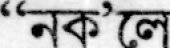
"নক'লে
